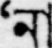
‘না
